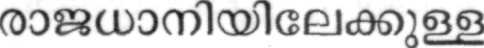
രാജധാനിയിലേക്കുള്ള
